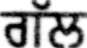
ਗੱਲ
